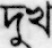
দুখ
